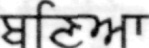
ਬਣਿਆ
